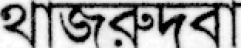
থাজরুদবা
